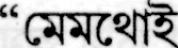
“মেমথোই
